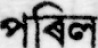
পৰিল
